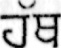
ਹੱਥ
